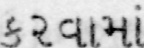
કરવામાં
